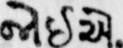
જોઈએ.
